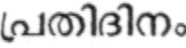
പ്രതിദിനം
